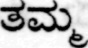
ತಮ್ಮ
